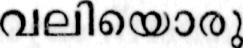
വലിയൊരു
